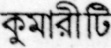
কুমারীটি
